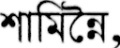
শামিন্নৈ,
